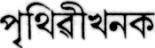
পৃথিৱীখনক
